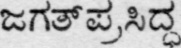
ಜಗತ್ಪ್ರಸಿದ್ಧ
